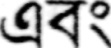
এবং
